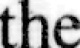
the
